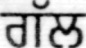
ਗੱਲ
